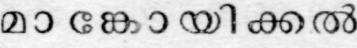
മാങ്കോയിക്കല്‍
